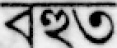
বহুত
